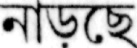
নাড়ছে
